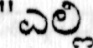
“ಎಲ್ಲಿ
